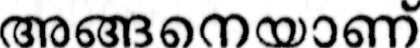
അങ്ങനെയാണ്
